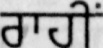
ਰਾਹੀਂ
